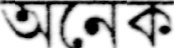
অনেক
